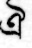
ঐ
